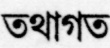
তথাগত
